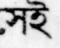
সেই
